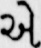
એ
